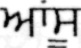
ਆਂਸੂ
